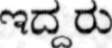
ಇದ್ದರು
